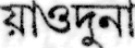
য়াওদুনা
